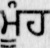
ਮੂੰਹ
